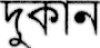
দুকান
